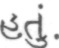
હતું.
